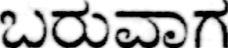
ಬರುವಾಗ
